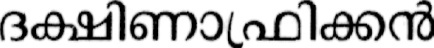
ദക്ഷിണാഫ്രിക്കന്‍
